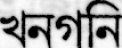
খনগনি
